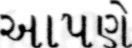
આપણે
